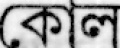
কোল
